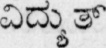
ವಿದ್ಯುತ್
